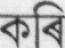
কৰি
